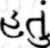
હતું
